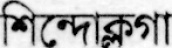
শিন্দোক্লগা
